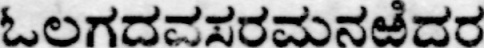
ಓಲಗದವಸರಮನಱೆದರ
